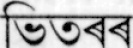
ভিতৰৰ
